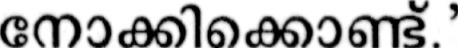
നോക്കിക്കൊണ്ട്.’
